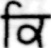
ਕਿ
